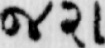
જરા
